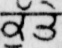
ਕੁੱਤੇ
